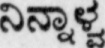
ನಿನ್ನಾಳ್ವ
